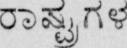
ರಾಷ್ಟ್ರಗಳ
